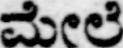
ಮೇಲೆ
